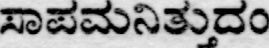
ಸಾಪಮನಿತ್ತುದಂ
